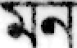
মন
